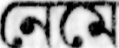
নেমে
